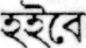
হইবে
